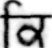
ਕਿ
